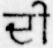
ਦੀ
